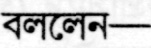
বললেন–
